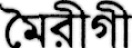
মৈরীগী
